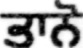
ਭਾਨੋ
